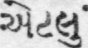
એટલું
